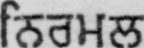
ਨਿਰਮਲ
